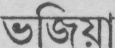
ভজিয়া
